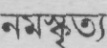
নমস্কৃত্য
